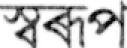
স্বৰূপ
